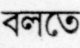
বলতে
